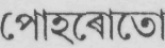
পোহৰোতো
